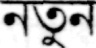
নতুন
